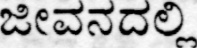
ಜೀವನದಲ್ಲಿ
